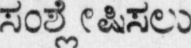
ಸಂಶ್ಲೇಷಿಸಲು
